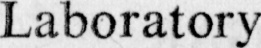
Laboratory
